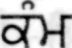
ਕੰਮ
